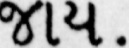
જાય.
